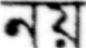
নয়
